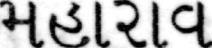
મહારાવ
